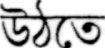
উঠতে
